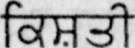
ਕਿਸ਼ਤੀ
